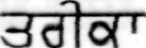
ਤਰੀਕਾ
